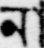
না
